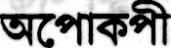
অপোকপী
